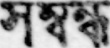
সম্বন্ধ
